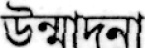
উন্মাদনা
